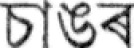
চাঙৰ
